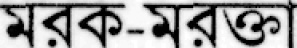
মরক-মরক্তা
